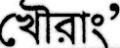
খৌরাং’
